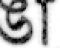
ঙা
